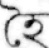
হৈ
